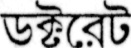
ডক্টরেট
